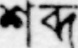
শব্দ
